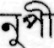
নুপী
